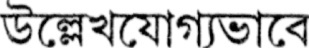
উল্লেখযোগ্যভাবে
